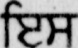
ਇਸ
